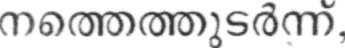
നത്തെത്തുടര്‍ന്ന്,
